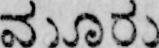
ಮೂರು
